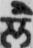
ਲੈ
